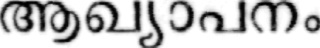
ആഖ്യാപനം
